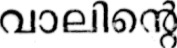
വാലിന്റെ
